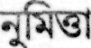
নুমিত্তা
